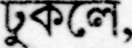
ঢুকলে,
